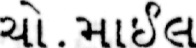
ચો.માઈલ
